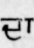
ਦਾ
